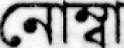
নোম্বা
